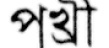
পুখ্রী
